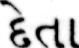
દેતા
